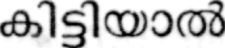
കിട്ടിയാല്‍
